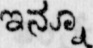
ಇನ್ನೂ
